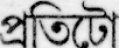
প্রতিটো
